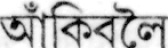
আঁকিবলৈ
